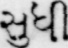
સુધી
